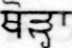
ਥੋੜ੍ਹਾ
